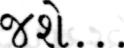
જશે...
